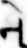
ને
